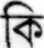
কি
